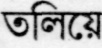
তলিয়ে
